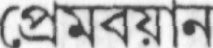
প্রেমবয়ান
